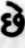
છે
